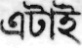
এটাই
